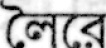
লৈরে
